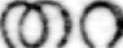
തറ
